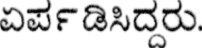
ಏರ್ಪಡಿಸಿದ್ದರು.
